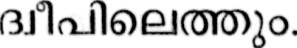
ദ്വീപിലെത്തും.
